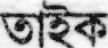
তাইক
